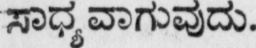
ಸಾಧ್ಯವಾಗುವುದು.
